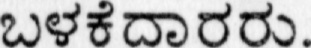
ಬಳಕೆದಾರರು.
